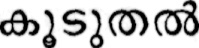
കൂടുതല്‍
